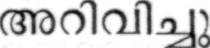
അറിവിച്ചു
